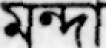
মন্দা
